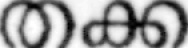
തക്ക
